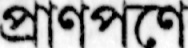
প্রাণপণে
